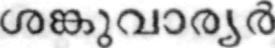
ശങ്കുവാര്യര്‍
